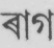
ৰাগ
